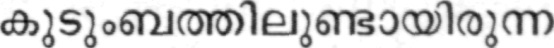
കുടുംബത്തിലുണ്ടായിരുന്ന
